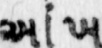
આંખ
